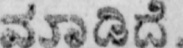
ಮಾಡಿದೆ.
